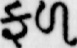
ફળ
